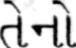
તેનો
